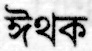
ঈথক
